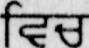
ਵਿਚ
